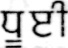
ਧੂਈ
